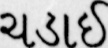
ચડાઈ
